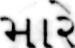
મારે
